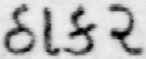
ઠાકર
